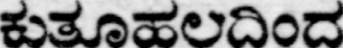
ಕುತೂಹಲದಿಂದ
